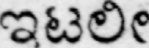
ಇಟಲೀ
